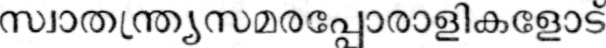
സ്വാതന്ത്ര്യസമരപ്പോരാളികളോട്
